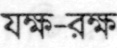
যক্ষ-রক্ষ
